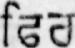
ਫਿਰ
